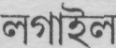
লগাইল
